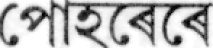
পোহৰেৰে
